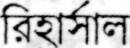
রিহার্সাল
